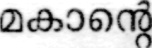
മകാന്റെ
